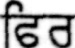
ਫਿਰ
